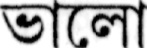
ভালো
